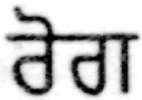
ਰੋਗ
